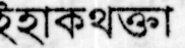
ইহাকথক্তা
